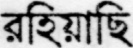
রহিয়াছি
